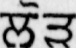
ਲੋੜ
